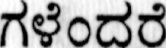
ಗಳೆಂದರೆ
